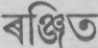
ৰঞ্জিত
